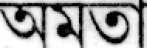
অমতা
